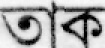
তাক
